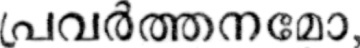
പ്രവര്‍ത്തനമോ,
